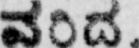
ವರಿದ.
